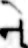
ને
